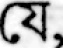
যে,
